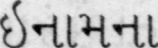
ઈનામના
